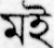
মই
